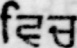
ਵਿਚ
